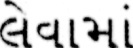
લેવામાં
